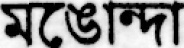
মঙোন্দা
